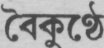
বৈকুণ্ঠে
